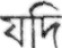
যদি
